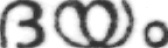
ദയം
